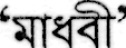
‘মাধবী’
